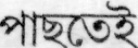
পাছতেই
